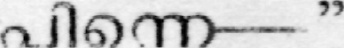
പിന്നെ-''
